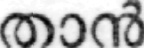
താന്‍
